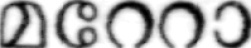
മറേറാ
